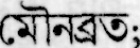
মৌনব্ৰত;
